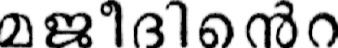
മജീദിന്റെ
